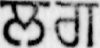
ਲਗ
